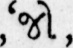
જો,
